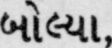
બોલ્યા,
